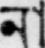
না
